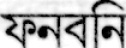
ফনবনি
